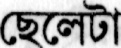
ছেলেটা
